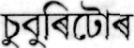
চুবুৰিটোৰ
